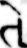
તે
